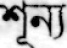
শূন্য
